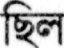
ছিল
